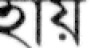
হায়
